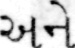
અને
